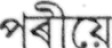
পৰীয়ে
